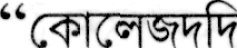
“কোলেজদদি
